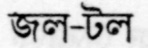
জল-টল
